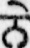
ਨੇ
